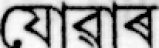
যোৱাৰ
